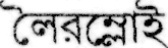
লৈরম্লোই
